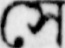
সে
